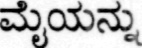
ಮೈಯನ್ನು
